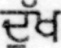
ਦੁੱਖ
